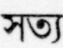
সত্য
